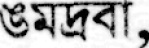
ঙমদ্রবা,
